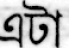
এটা
